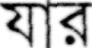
যার
